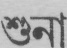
শুনা
